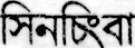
সিনচিংবা
